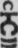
ਨੂੰ
